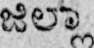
ಜಿಲ್ಲಾ
